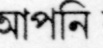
আপনি
